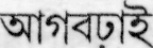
আগবঢ়াই
